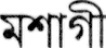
মশাগী
